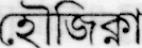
হৌজিক্না
